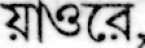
য়াওরে,
